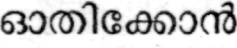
ഓതിക്കോന്‍
